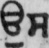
ਉਸ
